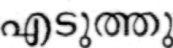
എടുത്തു
